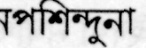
নপশিন্দুনা
